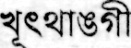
খূৎথাঙগী
